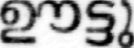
ഊട്ടു
